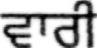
ਵਾਰੀ
